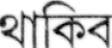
থাকিব
